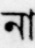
না
